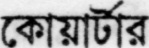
কোয়ার্টার
